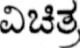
ವಿಚಿತ್ರ
